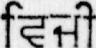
ਵਿਜੀ
